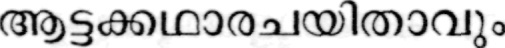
ആട്ടക്കഥാരചയിതാവും
